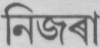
নিজৰা
